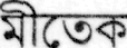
মীতেক
